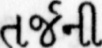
તર્જની
